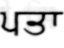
ਪਤਾ
